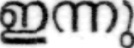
ഇന്നു
